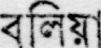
বলিয়া
